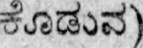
ಕೊಡುವ)
